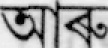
আৰু
